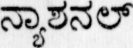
ನ್ಯಾಶನಲ್
